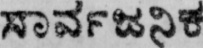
ಸಾರ್ವಜನಿಕ
